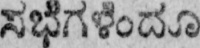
ಸಭೆಗಳೆಂದೂ
